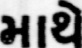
માથે
